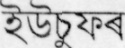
ইউচুফৰ
